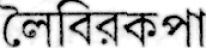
লৈবিরকপা
